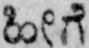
ಹೀಗೆ
